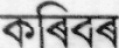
কৰিবৰ
